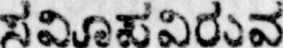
ಸಮೀಪವಿರುವ
